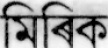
মিৰিক
